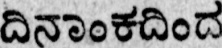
ದಿನಾಂಕದಿಂದ
